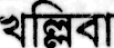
খল্লিবা
